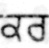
ਕਰ
